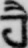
ਹੈ
